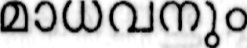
മാധവനും
